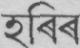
হৰিৰ
